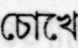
চোখে
